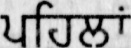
ਪਹਿਲਾਂ
